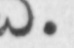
ಎ.
